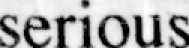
serious
